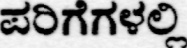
ಪರಿಗೆಗಳಲ್ಲಿ
